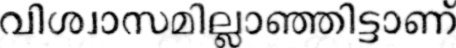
വിശ്വാസമില്ലാഞ്ഞിട്ടാണ്
